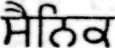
ਸੈਨਿਕ
